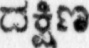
ದಕ್ಷಿಣ
